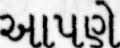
આપણે
